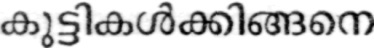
കുട്ടികള്‍ക്കിങ്ങനെ
